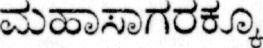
ಮಹಾಸಾಗರಕ್ಕೂ
